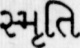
સ્મતિ
